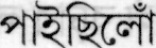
পাইছিলোঁ
